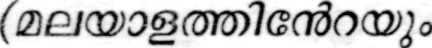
(മലയാളത്തിന്റേയും
